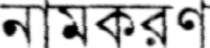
নামকরণ
